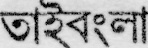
তাইবংলা
